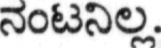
ನಂಟನಿಲ್ಲ.
